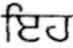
ਇਹ
